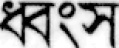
ধ্বংস
